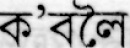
ক'বলৈ
